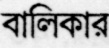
বালিকার
